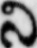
ನಿ
